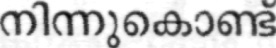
നിന്നുകൊണ്ട്
